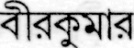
বীরকুমার
